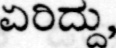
ಏರಿದ್ದು,
